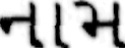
નામ
